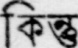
কিন্তু
